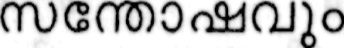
സന്തോഷവും
